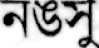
নঙসু
